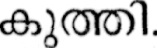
കുത്തി.
